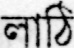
লাঠি
